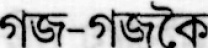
গজ-গজকৈ
